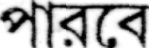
পারবে
